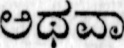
ಅಥವಾ
